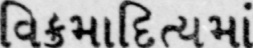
વિક્રમાદિત્યમાં
